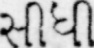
સીધી
